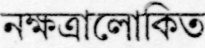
নক্ষত্রালোকিত
